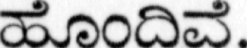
ಹೊಂದಿವೆ.
